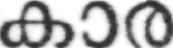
കാര
